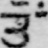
ਤੋਂ
